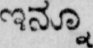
ಇನ್ನೂ
